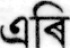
এৰি
